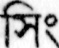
সিং
